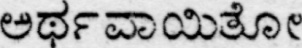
ಅರ್ಥವಾಯಿತೋ
